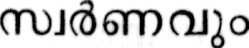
സ്വര്‍ണവും
